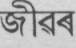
জীৱৰ
